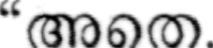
"അതെ.
